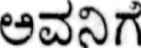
ಅವನಿಗೆ
